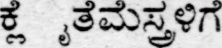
ಕ್ಲೈತೆಮೆಸ್ತ್ರಳಿಗೆ
